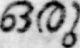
ഒരു
